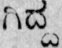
ಗಿದ್ದ
